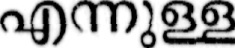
എന്നുള്ള
